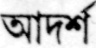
আদর্শ
